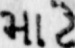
માટે
